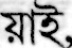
য়াই,
